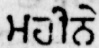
ਮਹੀਨੇ
